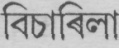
বিচাৰিলা
